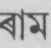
ৰাম
